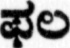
ಫಲ
